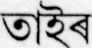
তাইৰ
